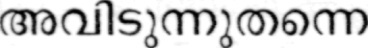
അവിടുന്നുതന്നെ
